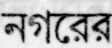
নগরের
